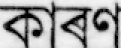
কাৰণ
